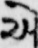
એ
